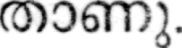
താണു.
